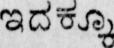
ಇದಕ್ಕೂ
